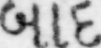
બાદ
